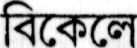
বিকেলে
